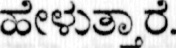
ಹೇಳುತ್ತಾರೆ.
